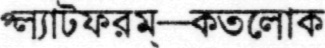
প্ল্যাটফরম্—কতলোক
